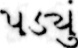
પડ્યું
